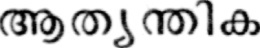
ആത്യന്തിക
